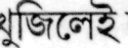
খুজিলেই
